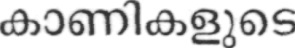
കാണികളുടെ
